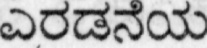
ಎರಡನೆಯ
